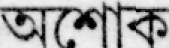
অশোক
